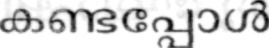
കണ്ടപ്പോള്‍
